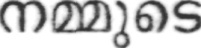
നമ്മുടെ
